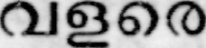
വളരെ
